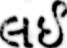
લઈ
